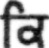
ਕਿ
